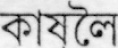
কাষলৈ
